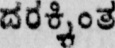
ದರಕ್ಕಿಂತ
